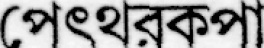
পেৎথরকপা
